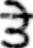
ਤੇ
